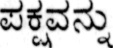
ಪಕ್ಷವನ್ನು
